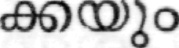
ക്കയും
